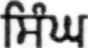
ਸਿੰਘ
